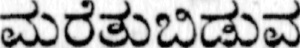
ಮರೆತುಬಿಡುವ
